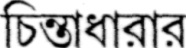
চিন্তাধারার
